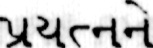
પ્રયત્નને
